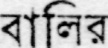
বালির
